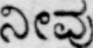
ನೀವು
